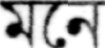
মনে
